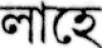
লাহে
